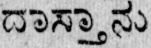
ದಾಸ್ತಾನು
